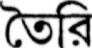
তৈরি
